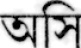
অসি
